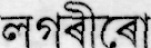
লগৰীৰো
